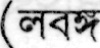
(লবঙ্গ
